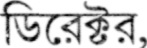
ডিরেক্টর,
